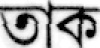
তাক
